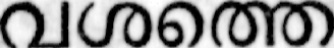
വശത്തെ
